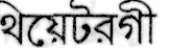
থিয়েটরগী
